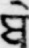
ਬੇ
